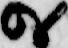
જ
